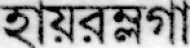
হায়রম্লগা
